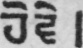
ਹੋਵੇ।
